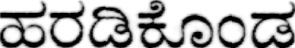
ಹರಡಿಕೊಂಡ
